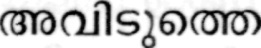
അവിടുത്തെ
